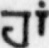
ਹਾਂ
